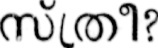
സ്ത്രീ?
